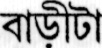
বাড়ীটা
